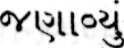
જણાવ્યું
